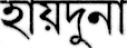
হায়দুনা
